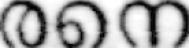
രനെ
